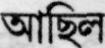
আছিল
